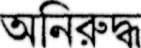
অনিরুদ্ধ
